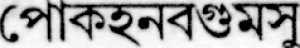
পোকহনবগুমসু
